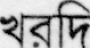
খরদি
